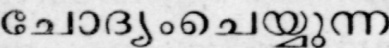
ചോദ്യംചെയ്യുന്ന
